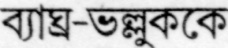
ব্যাঘ্র-ভল্লুককে
